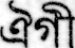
ঐগী
